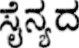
ಸೈನ್ಯದ
